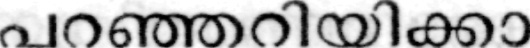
പറഞ്ഞറിയിക്കാ
